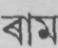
ৰাম
